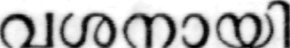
വശനായി
